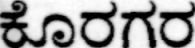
ಕೊರಗರ
